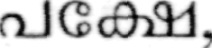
പക്ഷേ,
